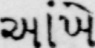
આંખે
